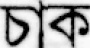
চাক
